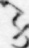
કે
